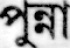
পুন্না
